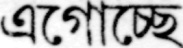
এগোচ্ছে
